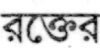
রক্তের
